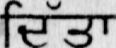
ਦਿੱਤਾ
